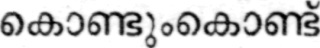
കൊണ്ടുംകൊണ്ട്
